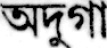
অদুদা
